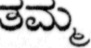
ತಮ್ಮ
